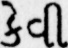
કેવી
